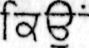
ਕਿਉਂ
